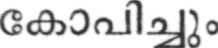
കോപിച്ചും
